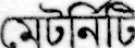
মেটনিটি
